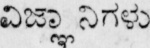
ವಿಜ್ಞಾನಿಗಳು
